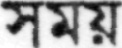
সময়
